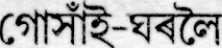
গোসাঁই-ঘৰলৈ
